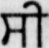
ਸੀ
